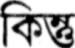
কিন্তু
